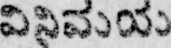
ವಿನಿಮಯ
